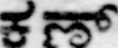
ಕಣ್
